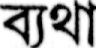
ব্যথা
